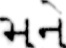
મને
